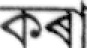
কৰা
